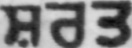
ਸ਼ਰਤ
